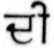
ਦੀ
